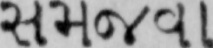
સમજવા
